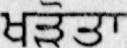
ਖੜੋਤਾ
